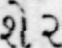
શેર
